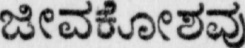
ಜೀವಕೋಶವು
